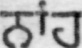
ਨਾਂਹ
